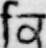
ਕਿ
